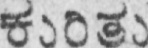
ಕುರಿತು
